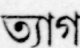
ত্যাগ
